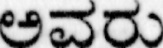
ಅವರು
